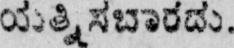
ಯತ್ನಿಸಬಾರದು.
